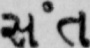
સંત
